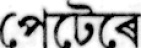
পেটেৰে
